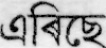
এৰিছে
